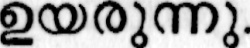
ഉയരുന്നു.
